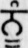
ਨੂੰ
